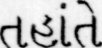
તહાંતે
